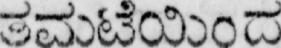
ತಮಟೆಯಿಂದ
